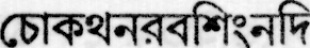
চোকথনরবশিংনদি
